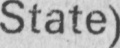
State)
